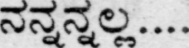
ನನ್ನನ್ನಲ್ಲ.....
